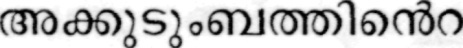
അക്കുടുംബത്തിന്റെ
